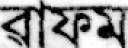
ৱাফম
